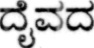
ದೈವದ
